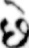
છે
